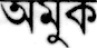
অমুক
